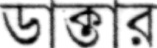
ডাক্তার
